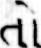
તો
